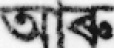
আৰু
